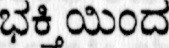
ಭಕ್ತಿಯಿಂದ
